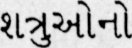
શત્રુઓનો
